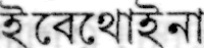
ইবেথোইনা
